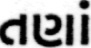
તણાં
